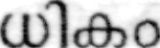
ധികം
